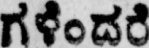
ಗಳೆಂದರೆ
